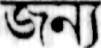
জন্য
